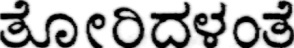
ತೋರಿದಳಂತೆ
